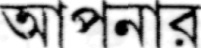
আপনার
